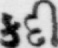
કદી
